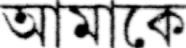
আমাকে
